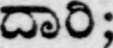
ದಾರಿ;
